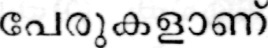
പേരുകളാണ്
